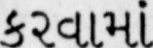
કરવામાં
